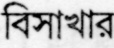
বিসাখার
